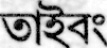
তাইবং
